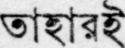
তাহারই
